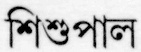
শিশুপাল
